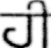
ਹੀ
